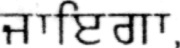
ਜਾਇਗਾ,
